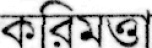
করিমত্তা
